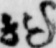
કઈ
